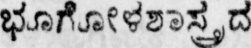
ಭೂಗೋಳಶಾಸ್ತ್ರದ
